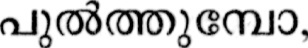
പുല്‍ത്തുമ്പോ,
